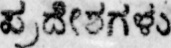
ಪ್ರದೇಶಗಳು
